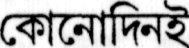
কোনোদিনই
